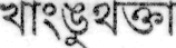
খাংঙুথক্তা
